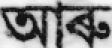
আৰু
